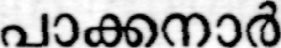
പാക്കനാര്‍
